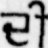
ਦੀ
